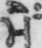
ਮੈਂ
